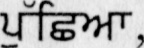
ਪੁੱਛਿਆ,
